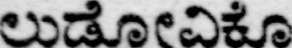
ಲುಡೋವಿಕೊ
